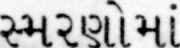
સ્મરણોમાં
